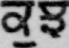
ਕੁਝ
